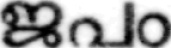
ജപം
